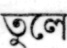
তুলে
